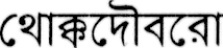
থোক্কদৌবরো
